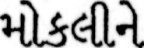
મોકલીને
